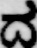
ದ
